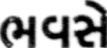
ભવસે
